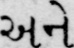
અને
